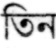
তিন
